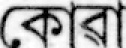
কোৱা
